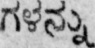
ಗಳನ್ನು
